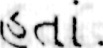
હતાં.
